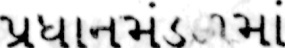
પ્રધાનમંડળમાં
